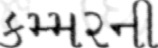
કમ્મરની
